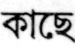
কাছে
